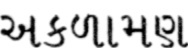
અકળામણ
